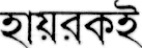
হায়রকই
